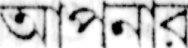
আপনার
